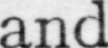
and
